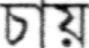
চায়
